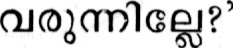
വരുന്നില്ലേ?'
